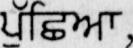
ਪੁੱਛਿਆ,
